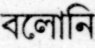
বলোনি
